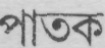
পাতক
